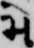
મે
